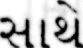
સાથે
